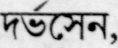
দর্ভসেন,
